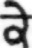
ਕੇ
